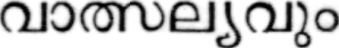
വാത്സല്യവും
